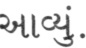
આવ્યું.
